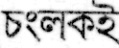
চংলকই
